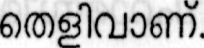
തെളിവാണ്.
